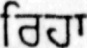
ਰਿਹਾ
